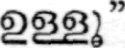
ഉള്ളൂ”
